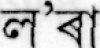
ল'ৰা
